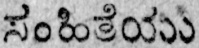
ಸಂಹಿತೆಯು
